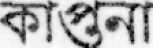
কাপ্তুনা
